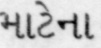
માટેના
